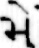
મેં
